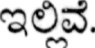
ಇಲ್ಲಿವೆ.
